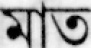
মাত
